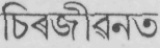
চিৰজীৱনত
